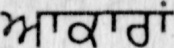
ਆਕਾਰਾਂ
